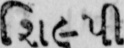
શિલ્પી
